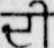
ਦੀ
